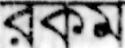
রকম
